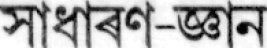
সাধাৰণ-জ্ঞান
